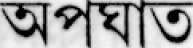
অপঘাত
